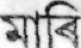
মাৰি
